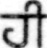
ਹੀ
